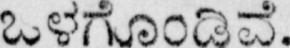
ಒಳಗೊಂಡಿವೆ.
